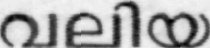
വലിയ
